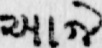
આજે
